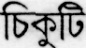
চিকুটি
